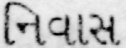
નિવાસ
